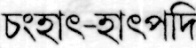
চংহাৎ-হাৎপদি
